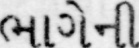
ભાગેની
